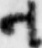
ન
